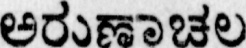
ಅರುಣಾಚಲ
